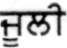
ਜੂਲੀ
